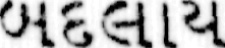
બદલાય
